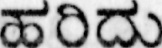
ಹರಿದು
